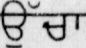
ਉੱਚਾ
